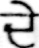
ਦੇ
